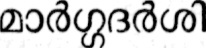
മാര്‍ഗ്ഗദര്‍ശി
